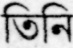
তিনি
